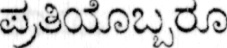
ಪ್ರತಿಯೊಬ್ಬರೂ
